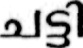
ചട്ടി
